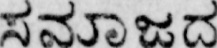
ಸಮಾಜದ
